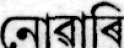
নোৱাৰি
